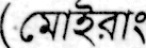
(মোইরাং
